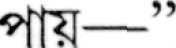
পায়-"
